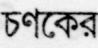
চণকের
